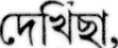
দেখিছা,
